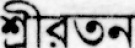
শ্রীরতন
